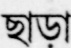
ছাড়া
